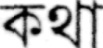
কথা
